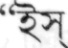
"ইস্
